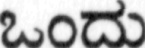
ಒಂದು
